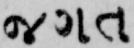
જગત
